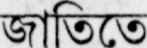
জাতিতে
